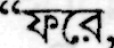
“ফরে,
